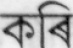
কৰি
